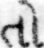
તો
